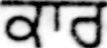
ਕਾਰ
